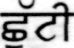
ਛੁੱਟੀ
